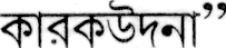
কারকউদনা”
